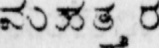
ಮಹತ್ತರ
